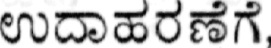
ಉದಾಹರಣೆಗೆ,
